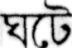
ঘটে
